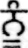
ਨੂੰ
